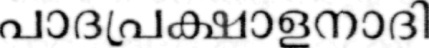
പാദപ്രക്ഷാളനാദി
